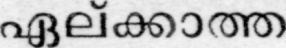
ഏല്ക്കാത്ത
